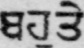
ਬਹੁਤੇ
